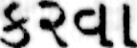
કરવા
